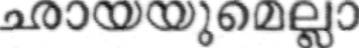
ഛായയുമെല്ലാ
